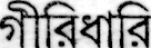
গীরিধারি
